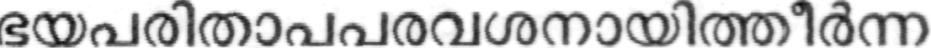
ഭയപരിതാപപരവശനായിത്തീര്‍ന്ന
